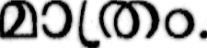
മാത്രം.
